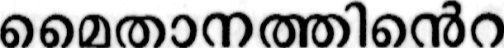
മൈതാനത്തിന്റെ
